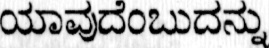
ಯಾವುದೆಂಬುದನ್ನು
